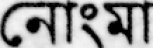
নোংমা
